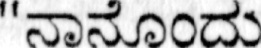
“ನಾನೊಂದು
